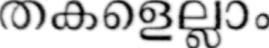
തകളെല്ലാം
